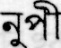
নুপী
